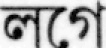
লগে
